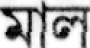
মাল
